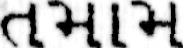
તમામ
